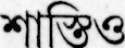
শাস্তিও
